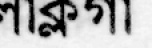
লাক্লগা
